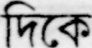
দিকে
